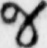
જ
